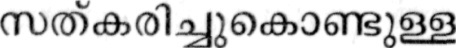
സത്കരിച്ചുകൊണ്ടുള്ള
